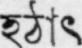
হঠাৎ
